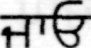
ਜਾਓ
